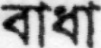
বাধা
